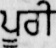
ਪੂਰੀ
